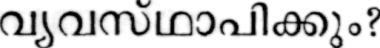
വ്യവസ്ഥാപിക്കും?
